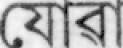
যোৱা
